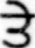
ਤੇ
